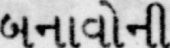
બનાવોની
